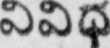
ವಿವಿಧ
